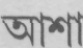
আশা
